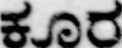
ಕೂರ
